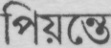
পিয়ন্তে
